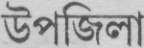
উপজিলা
